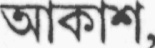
আকাশ,
